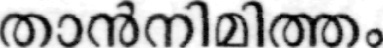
താന്‍നിമിത്തം
